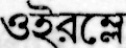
ওইরম্লে
